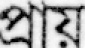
প্রায়
